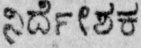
ನಿರ್ದೇಶಕ
